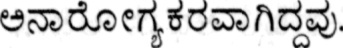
ಅನಾರೋಗ್ಯಕರವಾಗಿದ್ದವು.
